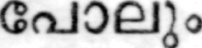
പോലും
